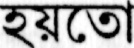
হয়তো
